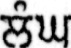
ਲੰਘ
